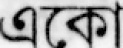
একো
